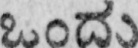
ಒಂದು
